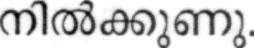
നില്‍ക്കുണു.
